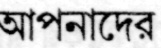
আপনাদের
